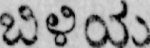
ಬಿಳಿಯ
